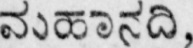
ಮಹಾನದಿ,
